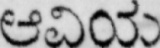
ಆವಿಯ
